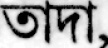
তাদা,
